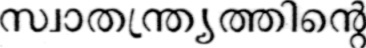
സ്വാതന്ത്ര്യത്തിന്റെ
